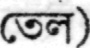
তেল)
